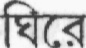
ঘিরে
